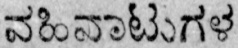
ವಹಿವಾಟುಗಳ
